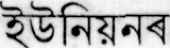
ইউনিয়নৰ
